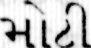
મોટી
